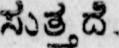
ಸುತ್ತದೆ.
